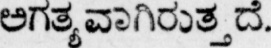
ಅಗತ್ಯವಾಗಿರುತ್ತದೆ.
